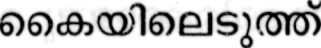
കൈയിലെടുത്ത്
